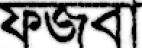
ফজবা
